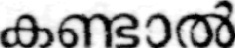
കണ്ടാല്‍
